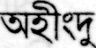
অহীংদু
